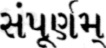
સંપૂર્ણમ્
